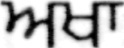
ਅਖਾਂ
